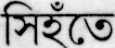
সিহঁতে
